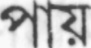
পায়
